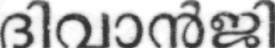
ദിവാന്‍ജി
